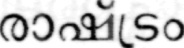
രാഷ്ട്രം
